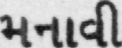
મનાવી
